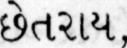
છેતરાય,
